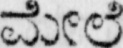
ಮೇಲೆ
